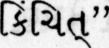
કિંચિત્"
